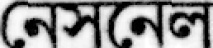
নেসনেল
